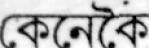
কেনেকৈ
